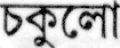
চকুলো
